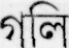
গলি
